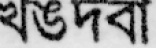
খঙদবা
